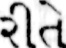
રીતે
